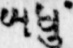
બધું
